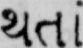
થતાં
